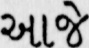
આજે
